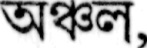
অঞ্চল,
